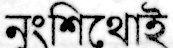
নুংশিথোই
